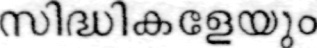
സിദ്ധികളേയും
